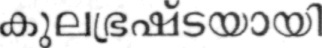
കുലഭ്രഷ്ടയായി
